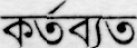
কর্তব্যত
